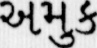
અમુક
